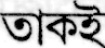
তাকই
